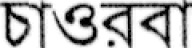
চাওরবা
